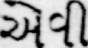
એવી
